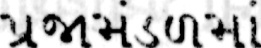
પ્રજામંડળમાં
